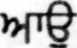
ਆਉ
